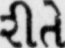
રીતે
